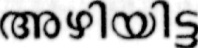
അഴിയിട്ട
